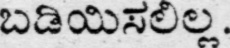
ಬಡಿಯಿಸಲಿಲ್ಲ.
